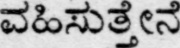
ವಹಿಸುತ್ತೇನೆ
